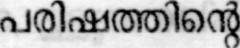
പരിഷത്തിന്റെ
